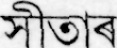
সীতাৰ
